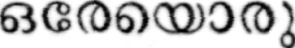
ഒരേയൊരു
